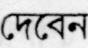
দেবেন
